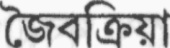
জৈবক্রিয়া
